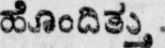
ಹೊಂದಿತ್ತು.
